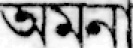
অমনা
